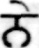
ਨੇ
